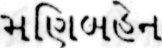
મણિબહેન
